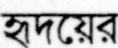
হৃদয়ের
